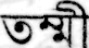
তম্মী
